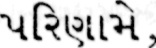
પરિણામે,
